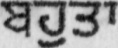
ਬਹੁਤਾ
